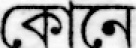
কোনে
